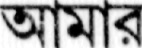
আমার
